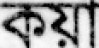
কয়া
